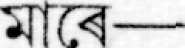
মাৰে-
